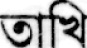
তাখি
